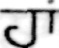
ਹਾਂ
